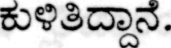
ಕುಳಿತಿದ್ದಾನೆ.
